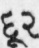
દૂર
